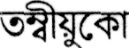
তম্বীয়ুকো
